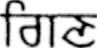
ਗਿਣ
